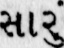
સારું
